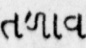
તળાવ
